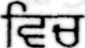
ਵਿਚ
